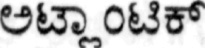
ಅಟ್ಲಾಂಟಿಕ್
